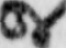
જ
